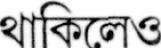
থাকিলেও
